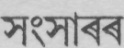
সংসাৰৰ
